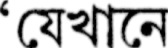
‘যেখানে
